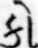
કો
